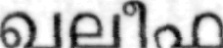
ഖലീഫ
